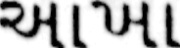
આખા
